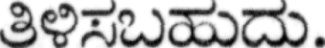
ತಿಳಿಸಬಹುದು.
